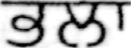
ਭਲਾ
